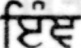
ਇੰਞ
